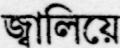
জ্বালিয়ে
